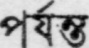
পর্যন্ত
